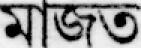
মাজত
